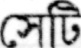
সেটি
